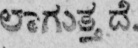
ಲಾಗುತ್ತದೆ.
